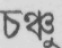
চঞ্চু
